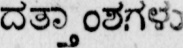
ದತ್ತಾಂಶಗಳು
